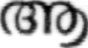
ആ
